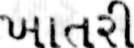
ખાતરી
